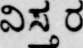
ವಿಸ್ತರ
